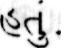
હતું.
